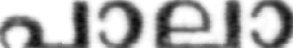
പാലാ
